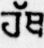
ਹੱਥ
